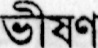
ভীষণ
